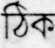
ঠিক
